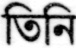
তিনি
